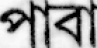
পাবা
